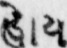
હોય
